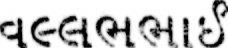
વલ્લભભાઈ
